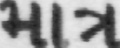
માત્ર
